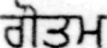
ਗੋਤਮ
